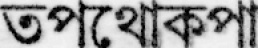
তপথোকপা
